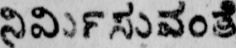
ನಿರ್ಮಿಸುವಂತೆ
